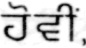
ਹੋਵੀਂ,
